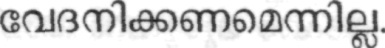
വേദനിക്കണമെന്നില്ല.
